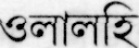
ওলালহি
